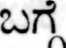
ಬಗ್ಗೆ
